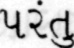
પરંતુ
